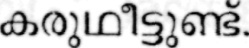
കരുഥീട്ടുണ്ട്.
